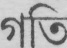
গতি
